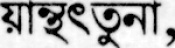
য়ান্থৎতুনা,
